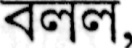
বলল,
